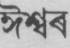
ঈশ্বৰ
